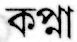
কপ্না
